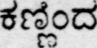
ಕಣ್ಣಿಂದ
